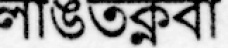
লাঙতক্নবা
